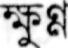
ক্ষুণ্ণ
